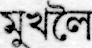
মুখলৈ
